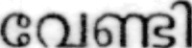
വേണ്ടി
